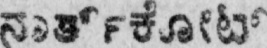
ನಾರ್ತ್‌ಕೋಟ್
